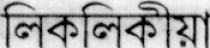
লিকলিকীয়া
